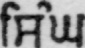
ਸਿੰਘ
